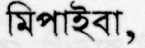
মিপাইবা,
